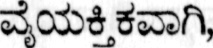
ವೈಯಕ್ತಿಕವಾಗಿ,
